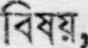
বিষয়,
